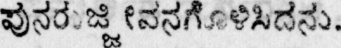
ಪುನರುಜ್ಜೀವನಗೊಳಿಸಿದನು.
